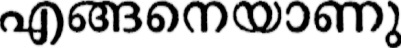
എങ്ങനെയാണു
